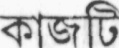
কাজটি
